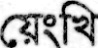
য়েংখি
